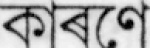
কাৰণে
